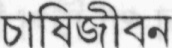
চাষিজীবন
